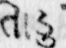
તોડું
